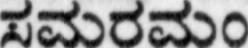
ಸಮರಮಂ
